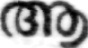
ആ
